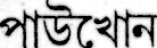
পাউখোন
